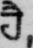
ਹੈ,
